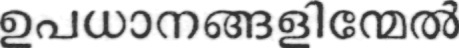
ഉപധാനങ്ങളിന്മേല്‍
